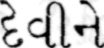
દેવીને
